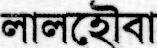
লালহৌবা
